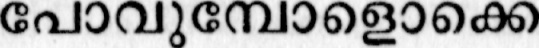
പോവുമ്പോളൊക്കെ
